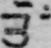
ਤੋਂ
